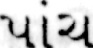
પાંચ
